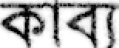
কাব্য
